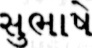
સુભાષે
